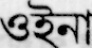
ওইনা
